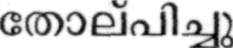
തോല്പിച്ചു
